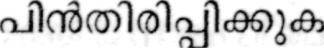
പിന്‍തിരിപ്പിക്കു
